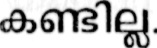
കണ്ടില്ല.
